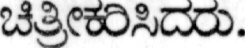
ಚಿತ್ರೀಕರಿಸಿದರು.
